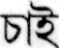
চাই
